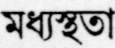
মধ্যস্থতা
